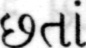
છતાં
